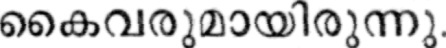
കൈവരുമായിരുന്നു.
